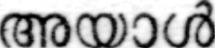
അയാള്‍
